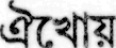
ঐখোয়
